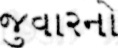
જુવારનો
